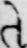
તે
